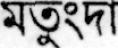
মতুংদা
